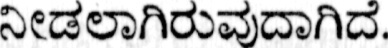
ನೀಡಲಾಗಿರುವುದಾಗಿದೆ.
